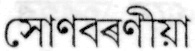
সোণবৰণীয়া
